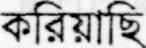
করিয়াছি
